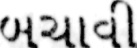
બચાવી
